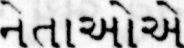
નેતાઓએ
